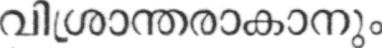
വിശ്രാന്തരാകാനും
